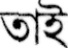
তাই
